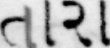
તારા
